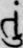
તું
